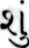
શું
